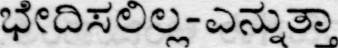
ಭೇದಿಸಲಿಲ್ಲ-ಎನ್ನುತ್ತಾ
